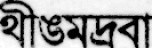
থীঙমদ্রবা
